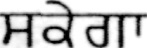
ਸਕੇਗਾ
